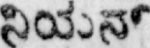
ನಿಯನ್
